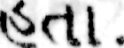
હતા.
